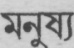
মনুষ্য
